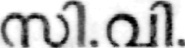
സി.വി.
